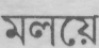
মলয়ে
